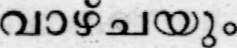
വാഴ്ചയും
